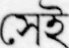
সেই
